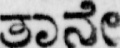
ತಾನೇ
